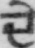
ਦੇ
